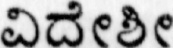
ವಿದೇಶೀ
